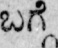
ಬಗ್ಗೆ
